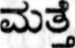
ಮತ್ತೆ
